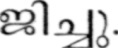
ജിച്ചു.
